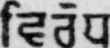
ਵਿਰੋਧ
